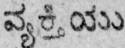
ವ್ಯಕ್ತಿಯು
